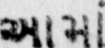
આમાં
